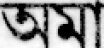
অমা
